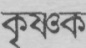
কৃষ্ণক
